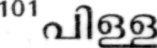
101പിള്ള
